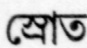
স্রোত
